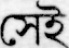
সেই
